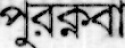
পুরক্নবা
